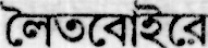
লৈতবোইরে
